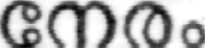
നേരം
